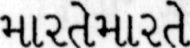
મારતેમારતે
